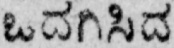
ಒದಗಿಸಿದ
